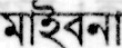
মাইবনা
